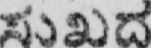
ಸುಖದ
